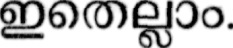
ഇതെല്ലാം.
